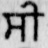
ਸੀ
